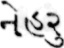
નેહરુ
